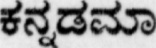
ಕನ್ನಡಮಾ
